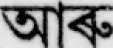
আৰু
